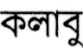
কলাবু
